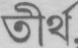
তীৰ্থ,
